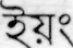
ইয়ং
